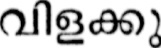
വിളക്കു
